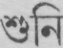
শুনি
